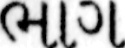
ભાગ
